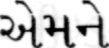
એમને
